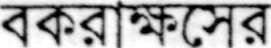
বকরাক্ষসের
